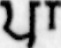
ਪਾ
